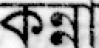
কন্না
